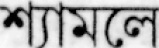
শ্যামলে
